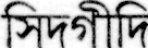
সিদগীদি
